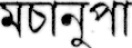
মচানুপা
